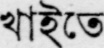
খাইতে
